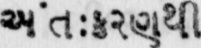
અંતઃકરણથી
